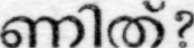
ണിത്?
